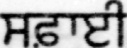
ਸਫ਼ਾਈ
